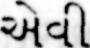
એવી
